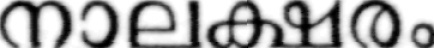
നാലക്ഷരം
